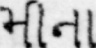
મીના
